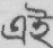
এই
